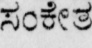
ಸಂಕೇತ
